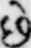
છે
